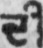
ਦੀ
